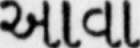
આવા
